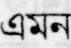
এমন
